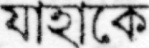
যাহাকে
